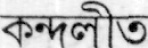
কন্দলীত
